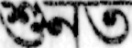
শুনত
